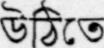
উঠিতে
